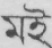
মই
